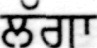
ਲੱਗਾ
